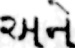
અને
